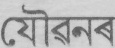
যৌৱনৰ
